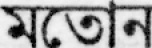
মতোন
